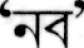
‘নব’
